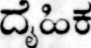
ದೈಹಿಕ
